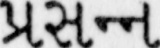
પ્રસન્ન
